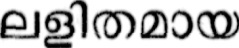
ലളിതമായ
